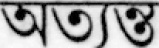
অত্যন্ত
